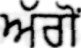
ਅੱਗੋਂ
